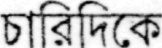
চারিদিকে
